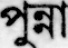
পুন্না
